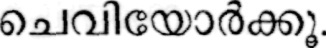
ചെവിയോര്‍ക്കൂ.
